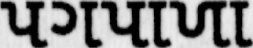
પગપાખા
